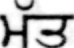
ਮੱਤ
